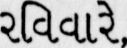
રવિવારે,
